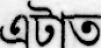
এটাত
